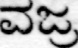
ವಜ್ರ
